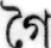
গৈ
